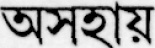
অসহায়
